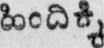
ಹಿಂದಿಕ್ಕಿ
